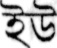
ইউ
